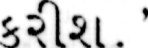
કરીશ.
